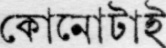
কোনোটাই
